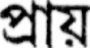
প্রায়
